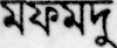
মফমদু
